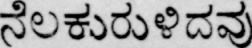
ನೆಲಕುರುಳಿದವು
